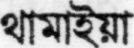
থামাইয়া
